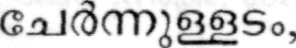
ചേര്‍ന്നുള്ളടം,
